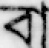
বা
